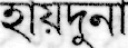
হায়দুনা
